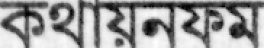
কথায়নফম
